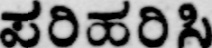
ಪರಿಹರಿಸಿ
